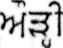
ਔੜ੍ਹੀ
